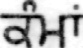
ਕੰਮਾਂ
